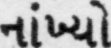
નાંખ્યો
